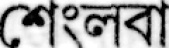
শেংলবা
